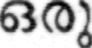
ഒരു
